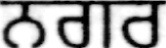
ਨਗਰ
